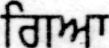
ਗਿਆ
